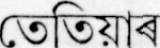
তেতিয়াৰ
